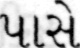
પાસે
